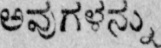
ಅವುಗಳನ್ನು
